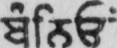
ਬੰਨਿਓਂ
